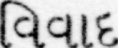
વિવાદ
